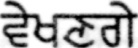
ਵੇਖਣਗੇ
